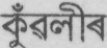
কুঁৱলীৰ
